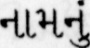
નામનું
